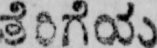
ತೆರಿಗೆಯ
